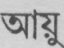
আয়ু
